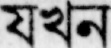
যখন
